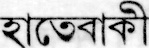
হাতেবাকী
